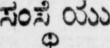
ಸಂಸ್ಥೆಯು
